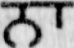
ਨਾ
